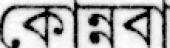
কোন্নবা
